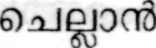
ചെല്ലാന്‍
